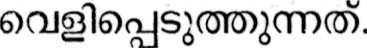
വെളിപ്പെടുത്തുന്നത്.
